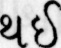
થઈ
